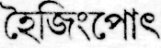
হৈজিংপোৎ
